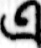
এ
